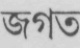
জগত
